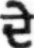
ਦੇ
